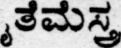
ತೆಮೆಸ್ತ್ರ
